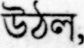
উঠল,
